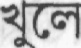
খুলে
